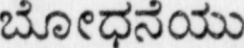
ಬೋಧನೆಯು
